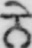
ਨੇ
